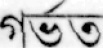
গর্ভত
